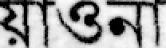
য়াওনা
